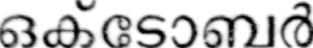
ഒക്ടോബര്‍
